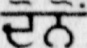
ਦੋਨੋਂ
